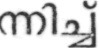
ന്നിച്ച്
